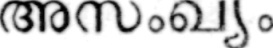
അസംഖ്യം
